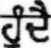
ਹੁੰਦੈ
